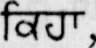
ਕਿਹਾ,
